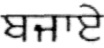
ਬਜਾਏ
